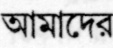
আমাদের
